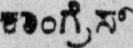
ಕಾಂಗ್ರೆಸ್
